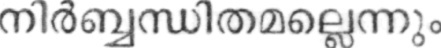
നിര്‍ബ്ബന്ധിതമല്ലെന്നും
